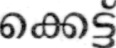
ക്കെട്ട്
